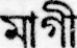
মগী
